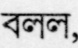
বলল,
